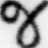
જ
